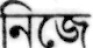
নিজে
